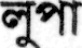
লুপা
